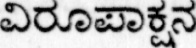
ವಿರೂಪಾಕ್ಷನ
